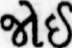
જોઈ
